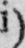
i)
